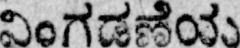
ವಿಂಗಡಣೆಯ
